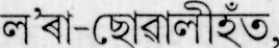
ল'ৰা-ছোৱালীহঁত,
